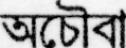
অচৌবা
